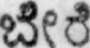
ಬೇರೆ
